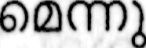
മെന്നു
